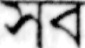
সব
